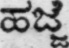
ಹಜ್ಜೆ
